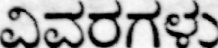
ವಿವರಗಳು
